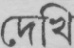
দেখি
